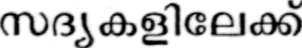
സദ്യകളിലേക്ക്
